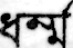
ধর্ম্ম
